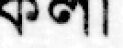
কলা
